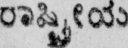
ರಾಷ್ಟ್ರೀಯ
